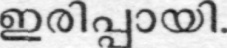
ഇരിപ്പായി.
